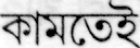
কামতেই
